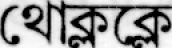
থোক্লক্লে
